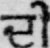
ਦੀ
